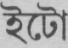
ইটো
